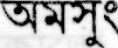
অমসুং
